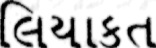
લિયાકત
